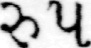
રુપ
